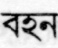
বহন
